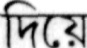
দিয়ে
